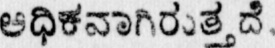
ಅಧಿಕವಾಗಿರುತ್ತದೆ.
